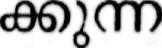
ക്കുന്ന
